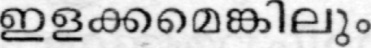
ഇളക്കമെങ്കിലും
